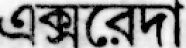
এক্সরেদা
